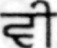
ਵੀ
